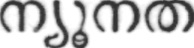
ന്യൂനത
